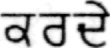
ਕਰਦੇ
